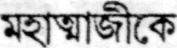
মহাত্মাজীকে
